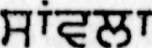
ਸਾਂਵਲਾ
